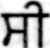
ਸੀ
